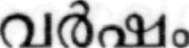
വര്‍ഷം
